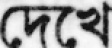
দেখে
